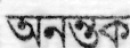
অনন্তক
